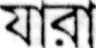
যারা
